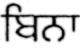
ਬਿਨਾ
